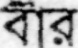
বার
